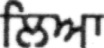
ਲਿਆ
